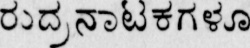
ರುದ್ರನಾಟಕಗಳೂ
